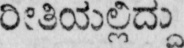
ರೀತಿಯಲ್ಲಿದ್ದು
